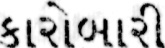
કારોબારી
